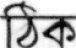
ঠিক
